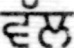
ਵੱਲ
